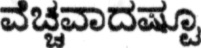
ವೆಚ್ಚವಾದಷ್ಟೂ
